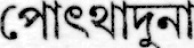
পোৎথাদুনা
